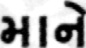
માને
